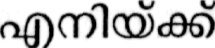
എനിയ്ക്ക്
